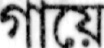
গায়ে
